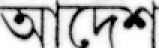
আদেশ
